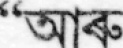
"আৰু
